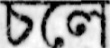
চলে
